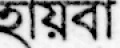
হায়বা
